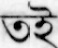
তই
